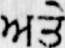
ਅਤੇ
